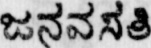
ಜನವಸತಿ
